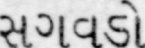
સગવડો
